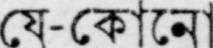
যে-কোনো
